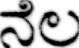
ನೆಲ
